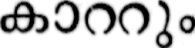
കാററും
